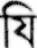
যি
